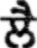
ਲੈ
